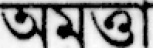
অমত্তা
